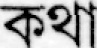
কথা
